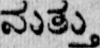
ಮತ್ತು
